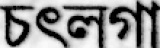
চৎলগা
